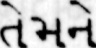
તેમને
